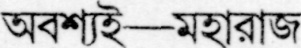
অবশ্যই–মহারাজ
